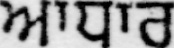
ਆਧਾਰ
